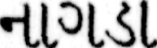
નાગડા
